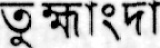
তুহ্মাংদা
